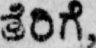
ತೆರಿಗೆ,
